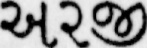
અરજી
